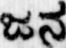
ಜನ
